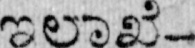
ಇಲಾಖೆ-
